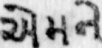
એમને
